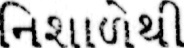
નિશાળેથી
